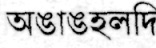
অঙাঙহলদি
